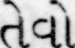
તેવો
